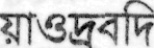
য়াওদ্রবদি
